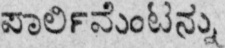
ಪಾರ್ಲಿಮೆಂಟನ್ನು
